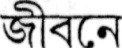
জীবনে
